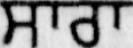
ਸਾਰਾ
